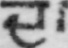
ਦਾ
